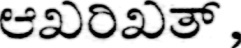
ಆಖರಿಖತ್,
